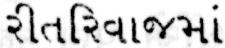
રીતરિવાજમાં
